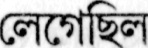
লেগেছিল
